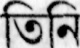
তিনি
